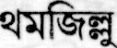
থমজিল্লু
